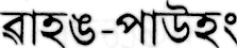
ৱাহঙ-পাউহং
